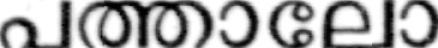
പത്താലോ
